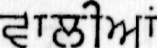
ਵਾਲੀਆਂ
